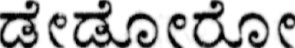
ಡೇಡೋರೋ
